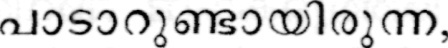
പാടാറുണ്ടായിരുന്ന,
